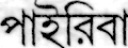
পাইরিবা
